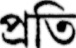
প্রতি
